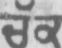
ਚੱਕ
